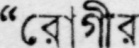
‘‘রোগীর
